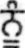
ਨੂੰ
